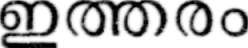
ഇത്തരം
